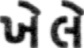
ખેલે
